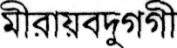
মীরায়বদুগগী
